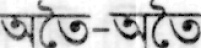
অতৈ-অতৈ
